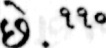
છે.૧૧૦
